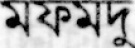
মফমদু
